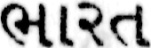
ભારત
